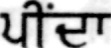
ਪੀਂਦਾ
